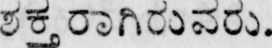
ಶಕ್ತರಾಗಿರುವರು.
